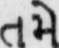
તમે
